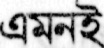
এমনই
